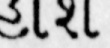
હાશ
